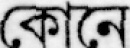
কোনে
